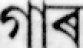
গাৰ
